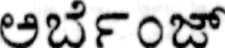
ಅರ್ಬೆಂಜ್
